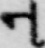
ન
